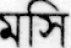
মসি
